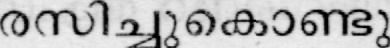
രസിച്ചുകൊണ്ടു
